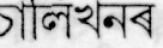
চালিখনৰ
